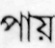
পায়
